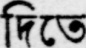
দিতে
